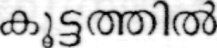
കൂട്ടത്തില്‍
